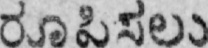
ರೂಪಿಸಲು
